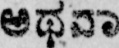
ಅಥವಾ
